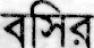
বসির
